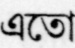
এতো
